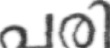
പരി
